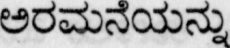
ಅರಮನೆಯನ್ನು
